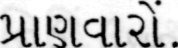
પ્રાણવારોં.
